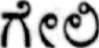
ಗೇಲಿ
